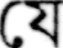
যে
